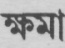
ক্ষমা
